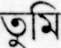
তুমি
